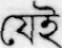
যেই
